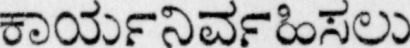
ಕಾರ್ಯನಿರ್ವಹಿಸಲು
